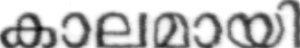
കാലമായി
